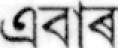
এবাৰ
